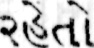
રહેતો
